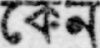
কেন
